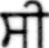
ਸੀ
